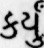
કર્યું
